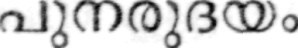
പുനരുദയം
